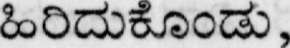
ಹಿರಿದುಕೊಂಡು,
